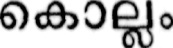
കൊല്ലം
